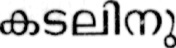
കടലിനു
